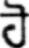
ਹੋ
